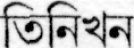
তিনিখন
